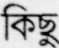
কিছু
